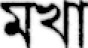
মখা
